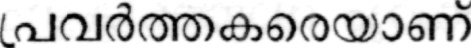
പ്രവര്‍ത്തകരെയാണ്
